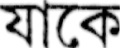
যাকে
